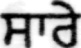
ਸਾਰੇ
